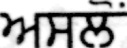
ਅਸਲੋਂ
